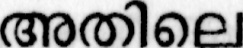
അതിലെ
